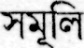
সমূলি
